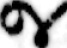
જ
